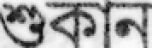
শুকান
